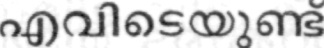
എവിടെയുണ്ട്
